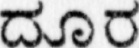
ದೂರ
